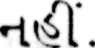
નહીં.
